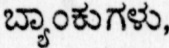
ಬ್ಯಾಂಕುಗಳು,
